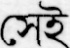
সেই
